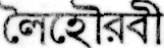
লৈহৌরবী
